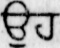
ਉਹ
